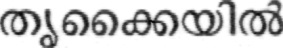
തൃക്കൈയില്‍
